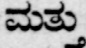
ಮತ್ತು
